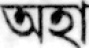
অহা
